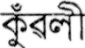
কুঁৱলী
